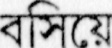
বসিয়ে
